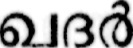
ഖദര്‍
